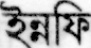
ইন্নফি
